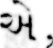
એ,
